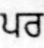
ਪਰ
